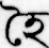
হৈ
